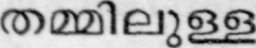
തമ്മിലുള്ള
